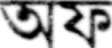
অফ
